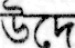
উদে
